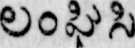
ಲಂಘಿಸಿ
